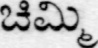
ಚಿಮ್ಮಿ
